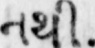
નથી.
